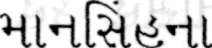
માનસિંહના
